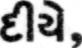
દીયે,
